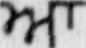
ਆ
